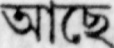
আছে
